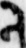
ને
